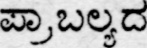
ಪ್ರಾಬಲ್ಯದ
